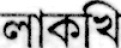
লাকখি
